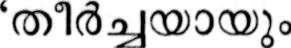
'തീര്‍ച്ചയായും
